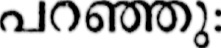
പറഞ്ഞു:
